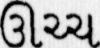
ઊચ્ચ
